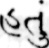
હતું
